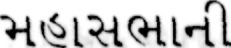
મહાસભાની
